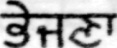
ਭੇਜਣਾ
